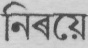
নিৰয়ে
